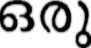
ഒരു
